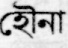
হৌনা
